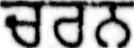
ਚਰਨ
